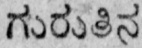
ಗುರುತಿನ
